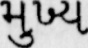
મુખ્ય
